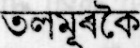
তলমূৰকৈ
